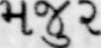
મજુર
